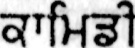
ਕਾਮਿਡੀ
